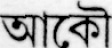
আকৌ
